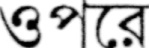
ওপরে
